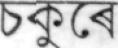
চকুৰে
